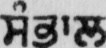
ਸੰਭਾਲ
